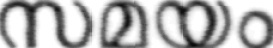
സമയം
